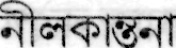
নীলকান্তনা
